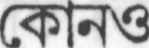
কোনও
